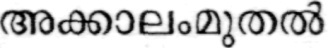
അക്കാലംമുതല്‍
